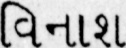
વિનાશ
